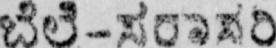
ಬೆಲೆ-ಸರಾಸರಿ
